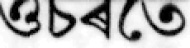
ওচৰতে
